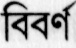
বিবর্ণ
